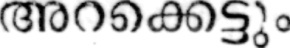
അറക്കെട്ടും
